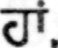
ਹਾਂ,
